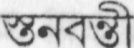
স্তনবন্তী
